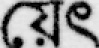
য়েৎ
